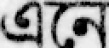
এনে
